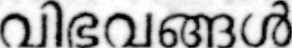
വിഭവങ്ങള്‍
